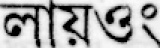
লায়ওং
